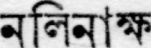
নলিনাক্ষ
